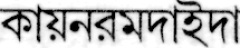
কায়নরমদাইদা
